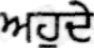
ਅਹੁਦੇ
